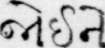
જોઈને
